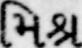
મિશ્ર
